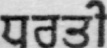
ਧਰਤੀ
